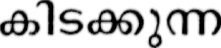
കിടക്കുന്ന
